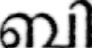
ബി
